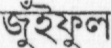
জুঁইফুল
